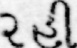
રહી
